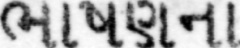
ભાષણના
